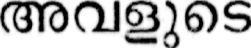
അവളുടെ
